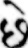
છે
